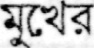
মুখের
